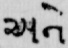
અને
